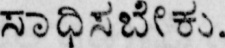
ಸಾಧಿಸಬೇಕು.
